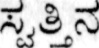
ಸ್ವತ್ತಿನ
